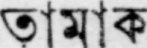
তামাক
